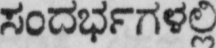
ಸಂದರ್ಭಗಳಲ್ಲಿ
